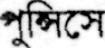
পুন্সিসে
